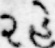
રહે
